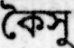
কৈসু
